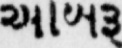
આબરૂ
